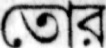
তোর
